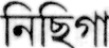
নিছিগা
